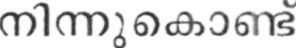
നിന്നുകൊണ്ട്
